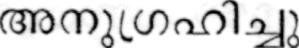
അനുഗ്രഹിച്ചു
